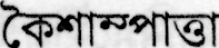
কৈশাম্পাত্তা
